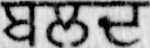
ਬਲਦ
